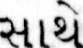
સાથે
